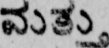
ಮತ್ತು
